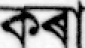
কৰা
